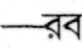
–রব
